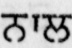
ਨਾਲ
